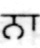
ਨਾ
